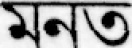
মনত
